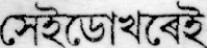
সেইডোখৰেই
